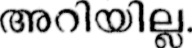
അറിയില്ല.
